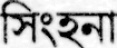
সিংহনা
